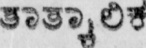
ತಾತ್ಕಾಲಿಕ
